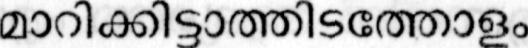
മാറിക്കിട്ടാത്തിടത്തോളം
